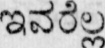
ಇವರೆಲ್ಲ
